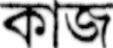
কাজ
